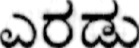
ಎರಡು
